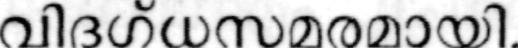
വിദഗ്ധസമരമായി.
